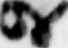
જ
